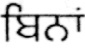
ਬਿਨਾਂ
